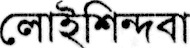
লোইশিন্দবা
